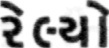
રેલ્યો
